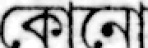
কোনো
